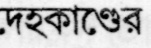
দেহকাণ্ডের
